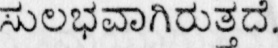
ಸುಲಭವಾಗಿರುತ್ತದೆ.
